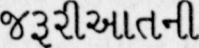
જરૂરીઆતની
